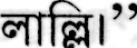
লাল্লি।”
